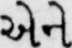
એને
